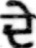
ਦੇ
